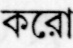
করো
